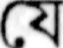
যে
